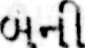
બની
